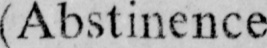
(Abstinence
